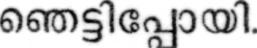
ഞെട്ടിപ്പോയി.
